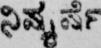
ನಿಷ್ಕರ್ಷೆ
